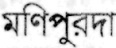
মণিপুরদা
